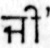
ਜੀ'
